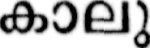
കാലു
